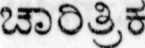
ಚಾರಿತ್ರಿಕ
